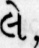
લે,
